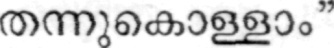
തന്നുകൊള്ളാം”
